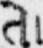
તો
